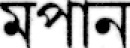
মপান
